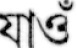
যাওঁ
